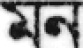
মন
